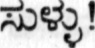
ಸುಳ್ಳು!
